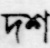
দশ
